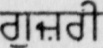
ਗੁਜ਼ਰੀ
